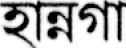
হান্নগা
